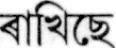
ৰাখিছে
